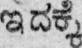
ಇದಕ್ಕೆ
